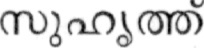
സുഹൃത്ത്
